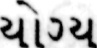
યોગ્ય
